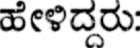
ಹೇಳಿದ್ದರು:
